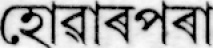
হোৱাৰপৰা
